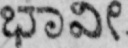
ಭಾವೀ
